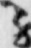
કે
